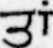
ਤਾਂ
